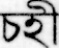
চহী
